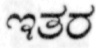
ಇತರ
